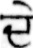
ਦੇ
